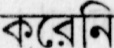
করেনি
